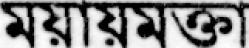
ময়ায়মক্তা
